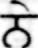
ਨੇ
